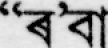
"ৰ'বা
